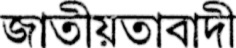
জাতীয়তাবাদী
